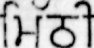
ਮਿੱਠੀ
